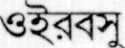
ওইরবসু
